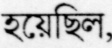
হয়েছিল,
